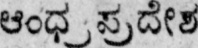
ಆಂಧ್ರಪ್ರದೇಶ
